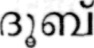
ദൂബ്
